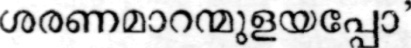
ശരണമാറന്മുളയപ്പോ’
